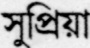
সুপ্রিয়া
